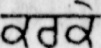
ਕਰਕੇ
